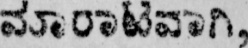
ಮಾರಾಟವಾಗಿ,
